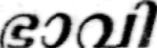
ഭാവി
